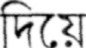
দিয়ে
